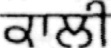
ਕਾਲੀ
